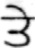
ਤੇ
